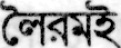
লৈরমই
